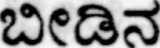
ಬೀಡಿನ
